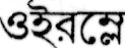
ওইরম্লে
